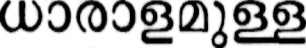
ധാരാളമുള്ള
